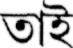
তাই
